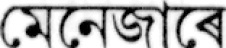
মেনেজাৰে
